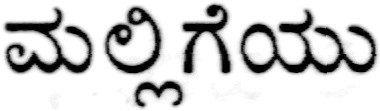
ಮಲ್ಲಿಗೆಯು
